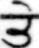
ਤੇ
